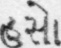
હસો
